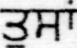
ਤੁਸਾਂ
